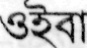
ওইবা
